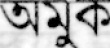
অমুক
